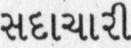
સદાચારી
